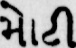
મોટી
